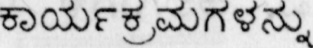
ಕಾರ್ಯಕ್ರಮಗಳನ್ನು
